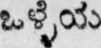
ಒಳ್ಳೆಯ
